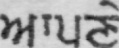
ਆਪਣੇ
